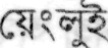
য়েংলুই
